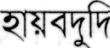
হায়বদুদি
